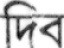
দিব
